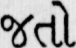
જતો
